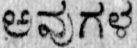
ಅವುಗಳ
